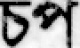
চপ
